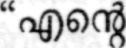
“എന്റെ
